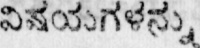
ವಿಷಯಗಳನ್ನು
